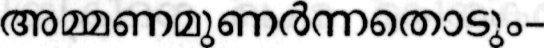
അമ്മണമുണര്‍ന്നതൊടും-
